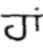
ਹਾਂ
